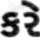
કરે
